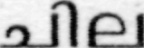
ചില
